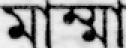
মাম্মা
